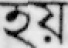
হয়
